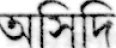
অসিদি
